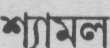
শ্যামল
